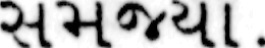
સમજ્યા.
